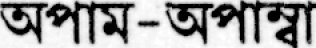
অপাম-অপাম্বা
